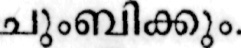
ചുംബിക്കും.
